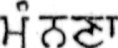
ਮੰਨਣਾ
